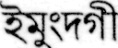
ইমুংদগী
